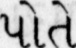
પોતે
